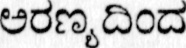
ಅರಣ್ಯದಿಂದ
